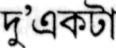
দু’একটা
